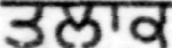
ਤਲਾਕ
